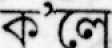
ক'লে
